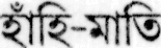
হাঁহি-মাতি
